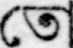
তো
